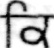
ਕਿ
